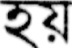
হয়
